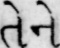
તેને
